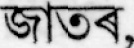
জাতৰ,
